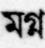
মগ্ন
